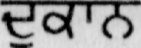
ਦੁਕਾਨ
